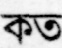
কত
